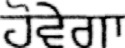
ਹੋਵੇਗਾ
